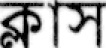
ক্লাস
